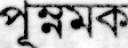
পূম্নমক
